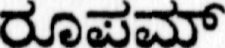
ರೂಪಮ್
